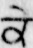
ਕੇ
